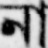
না
